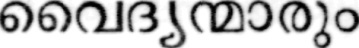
വൈദ്യന്മാരും
